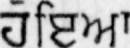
ਹੋਇਆ
